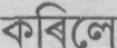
কৰিলে
